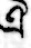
ঐ
